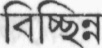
বিচ্ছিন্ন
